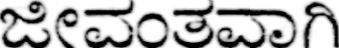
ಜೀವಂತವಾಗಿ
